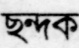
ছন্দক
